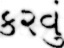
કરવું
